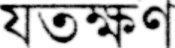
যতক্ষণ
